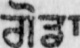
ਗੋਡਾ
